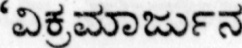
‘ವಿಕ್ರಮಾರ್ಜುನ
